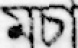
মচা
